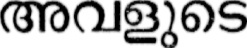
അവളുടെ
